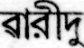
ৱারীদু
